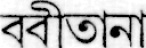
ববীতানা
